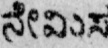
ನೇಮಿಸ
